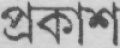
প্ৰকাশ
